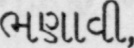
ભણાવી,
